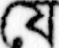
যে
